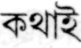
কথাই
